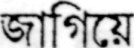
জাগিয়ে
